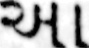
આ
